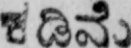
ಕಡಿಮೆ
